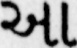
આ
